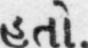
હતો.
